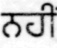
ਨਹੀਂ
